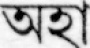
অহা
